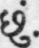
છું.
